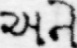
અને
